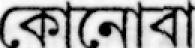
কোনোবা
